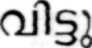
വിട്ടു
